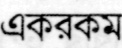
একরকম
